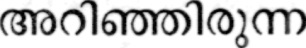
അറിഞ്ഞിരുന്ന
